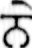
ਨੇ
